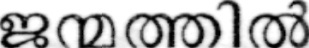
ജന്മത്തില്‍
